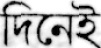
দিনেই
